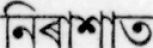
নিৰাশাত
